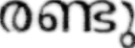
രണ്ടു
